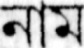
নাম
